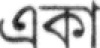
একা
